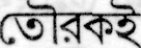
তৌরকই
